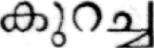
കുറച്ച
